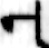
ન
